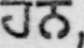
ਹਨ,
